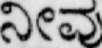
ನೀವು
